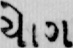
યોગ
